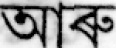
আৰু
